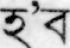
হ'ব
